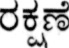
ರಕ್ಷಣೆ
